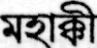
মহাক্কী
